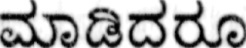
ಮಾಡಿದರೂ
